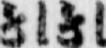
કાકા
